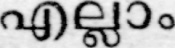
എല്ലാം
